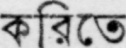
করিতে
